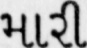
મારી
